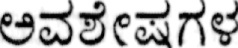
ಅವಶೇಷಗಳ
